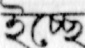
ইচ্ছে
